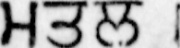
ਮਤਲ।
